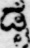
ಡೈ
